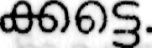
ക്കട്ടെ.
